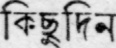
কিছুদিন
